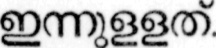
ഇന്നുളളത്.
